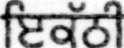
ਇਕੱਠੀ
